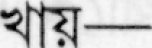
খায়-
